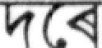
দৰে
